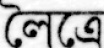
লৈত্রে
